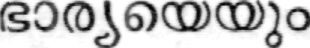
ഭാര്യയെയും
